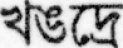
খঙদ্রে
